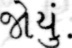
જોયું.
